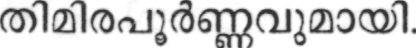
തിമിരപൂര്‍ണ്ണവുമായി.
